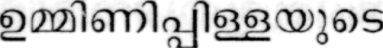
ഉമ്മിണിപ്പിള്ളയുടെ
